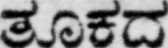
ತೂಕದ
